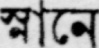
স্নানে
